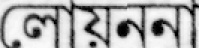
লোয়ননা
